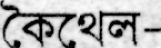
কৈথেল-
